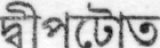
দ্বীপটোত
